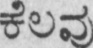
ಕೆಲವು
